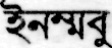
ইনম্মবু
